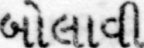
બોલાવી
